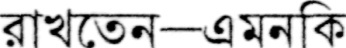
রাখতেন–এমনকি
